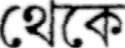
থেকে
